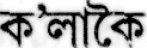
ক'লাকৈ
